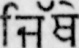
ਜਿੱਥੇ
